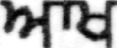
ਆਖ
